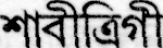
শাবীত্রিগী
